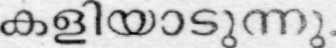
കളിയാടുന്നു.
